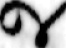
જ
